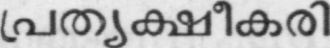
പ്രത്യക്ഷീകരി
